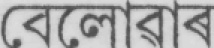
বেলোৱাৰ
